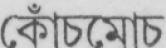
কোঁচমোচ
